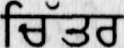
ਚਿੱਤਰ
